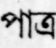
পাত্র
